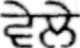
ਵੇਲੇ
